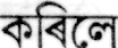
কৰিলে
